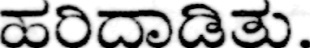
ಹರಿದಾಡಿತು.
